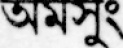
অমসুং
